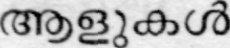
ആളുകള്‍
